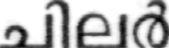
ചിലര്‍
